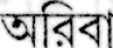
অরিবা
